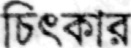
চিৎকার
